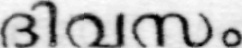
ദിവസം
